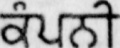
ਕੰਪਨੀ
